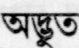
অদ্ভুত
